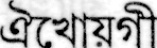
ঐখোয়গী
